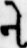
ને
